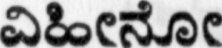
ವಿಹೀನೋ
